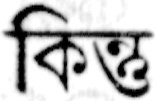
কিন্তু
